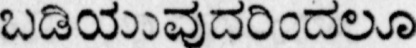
ಬಡಿಯುವುದರಿಂದಲೂ
